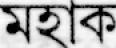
মহাক
